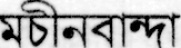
মচীনবান্দা
